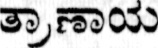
ತ್ರಾಣಾಯ
